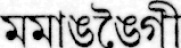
মমাঙঙৈগী
